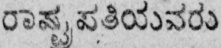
ರಾಷ್ಟ್ರಪತಿಯವರು
